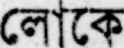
লোকে
